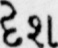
દેશ
